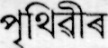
পৃথিৱীৰ
